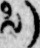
ಸಿ)
